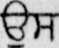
ਉਸ
